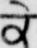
ਕੇ
